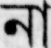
না
